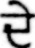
ਦੇ
